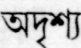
অদৃশ্য
